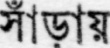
সাঁড়ায়
